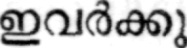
ഇവര്‍ക്കു
